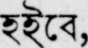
হইবে,
